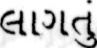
લાગતું
